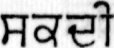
ਸਕਦੀ
